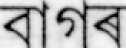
বাগৰ
